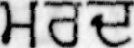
ਮਰਦ
